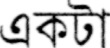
একটা
